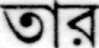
তার
